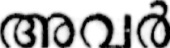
അവര്‍
